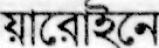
য়ারোইনে
